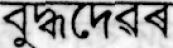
বুদ্ধদেৱৰ
